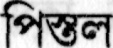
পিস্তল
